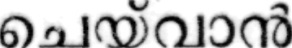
ചെയ്വാന്‍
